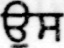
ਉਸ
